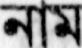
নাম
